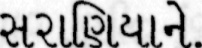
સરાણિયાને.
